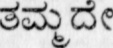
ತಮ್ಮದೇ
